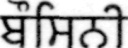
ਬੌਸਿਨੀ
